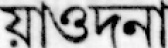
য়াওদনা
